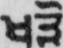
ਖੜੋ
